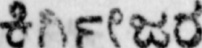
ಕಿರ್ಗೀಜರ
